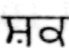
ਸ਼ਕ
